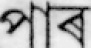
পাৰ
